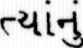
ત્યાંનું
